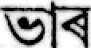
ভাৰ
